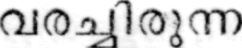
വരച്ചിരുന്ന
